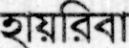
হায়রিবা
